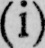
(i)
